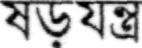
ষড়যন্ত্র
